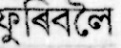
ফুৰিবলৈ
